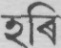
হৰি
